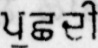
ਪੁਛਦੀ
